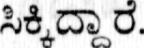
ಸಿಕ್ಕಿದ್ದಾರೆ.
